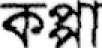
কপ্পা
